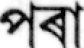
পৰা
